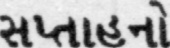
સપ્તાહનો
